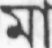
মা
